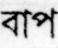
বাপ
